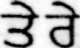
ਤੇਰੇ
